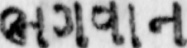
ભગવાન
